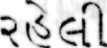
રહેલી
